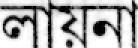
লায়না
